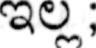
ಇಲ್ಲ;
